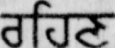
ਰਹਿਣ
